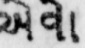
એવો
